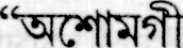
“অশোমগী
